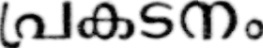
പ്രകടനം
